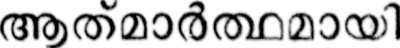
ആത്മാര്‍ത്ഥമായി
